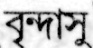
বৃন্দাসু
